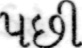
પછી
